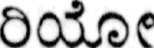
ರಿಯೋ
